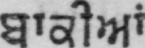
ਬਾਕੀਆਂ
